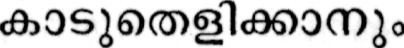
കാടുതെളിക്കാനും
